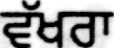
ਵੱਖਰਾ
